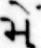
મેં
